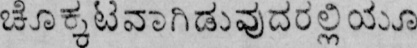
ಚೊಕ್ಕಟವಾಗಿಡುವುದರಲ್ಲಿಯೂ
